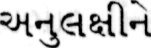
અનુલક્ષીને
